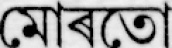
মোৰতো
